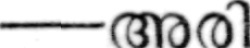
-അരി
